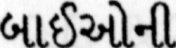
બાઈઓની
